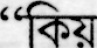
"কিয়
